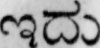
ಇದು
